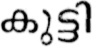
കുട്ടി
